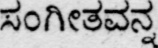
ಸಂಗೀತವನ್ನ
